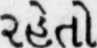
રહેતો
